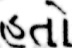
હતો
